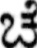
ಚೆ
